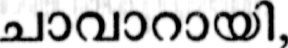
ചാവാറായി,
